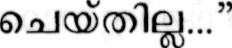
ചെയ്തില്ല...”
